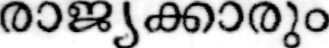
രാജ്യക്കാരും
